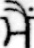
ਮੈਂ
